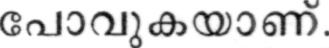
പോവുകയാണ്.
